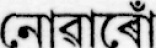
নোৱাৰোঁ
